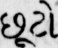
છૂટો
